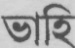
ভাহি
